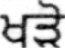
ਖੜੋ
